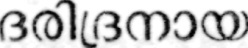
ദരിദ്രനായ
